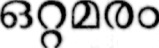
ഒറ്റമരം
